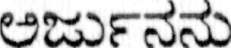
ಅರ್ಜುನನು
